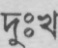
দুঃখ
